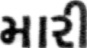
મારી
